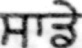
ਸਾਡੇ
